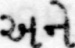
અને
